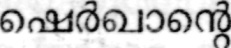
ഷെര്‍ഖാന്റെ
